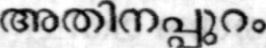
അതിനപ്പുറം
